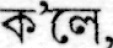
ক'লে,
